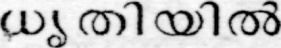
ധൃതിയില്‍
